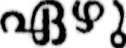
ഏഴു
